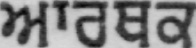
ਆਰਥਕ
